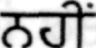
ਨਹੀਂ
